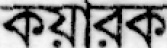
কয়ারক
